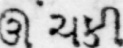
ઊંચકી
